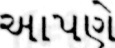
આપણે
